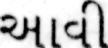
આવી
